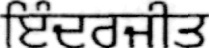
ਇੰਦਰਜੀਤ
